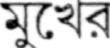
মুখের
